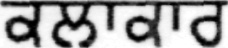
ਕਲਾਕਾਰ
